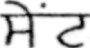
ਸੇਂਟ
